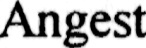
Angest
